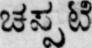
ಚಪ್ಪಟೆ
